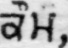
ਕੌਮ,
